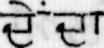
ਦੇਂਦਾ
